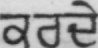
ਕਰਦੇ
